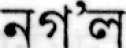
নগ'ল
